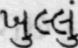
ખુલ્લું
